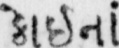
કોઈનાં
